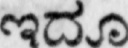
ಇದೂ
